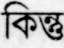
কিন্তু
